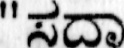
“ಸದಾ
